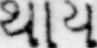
થાય
